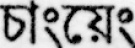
চাংয়েং
